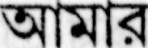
আমার
